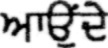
ਆਉਂਦੇ
